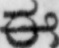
ಈ
